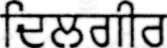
ਦਿਲਗੀਰ
